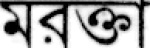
মরক্তা
